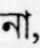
না,
